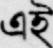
এই
